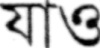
যাও
